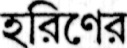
হরিণের
